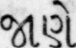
જાણે
